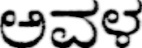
ಅವಳ
